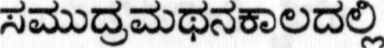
ಸಮುದ್ರಮಥನಕಾಲದಲ್ಲಿ
